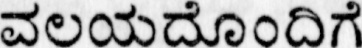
ವಲಯದೊಂದಿಗೆ
